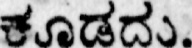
ಕೂಡದು.
